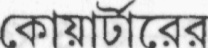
কোয়ার্টারের
